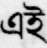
এই
